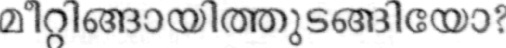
മീറ്റിങ്ങായിത്തുടങ്ങിയോ?
